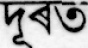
দূৰত
